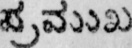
ಪ್ರಮುಖ
